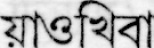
য়াওখিবা
